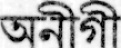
অনীগী
